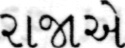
રાજાએ
